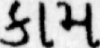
કામ
